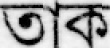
তাক
